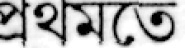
প্রথমতে
